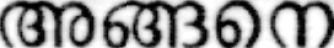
അങ്ങനെ
